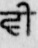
ਵੀ
